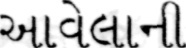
આવેલાની
